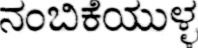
ನಂಬಿಕೆಯುಳ್ಳ
